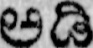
ಅಡಿ
